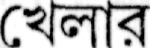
খেলার
